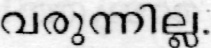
വരുന്നില്ല.
